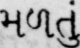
મળતું
